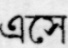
এসে
